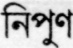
নিপুণ
